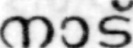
നാട്
